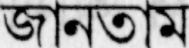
জানতাম
